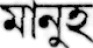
মানুহ
